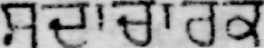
ਸਦਾਚਾਰਕ
